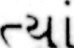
ત્યાં
